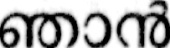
ഞാന്‍
